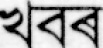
খবৰ
